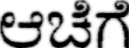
ಆಚೆಗೆ
